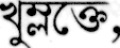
খুম্লক্তে,
